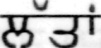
ਲੱਤਾਂ
